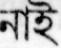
নাই
